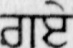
ਗਏ
